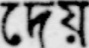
দেয়
